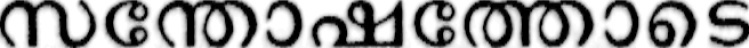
സന്തോഷത്തോടെ
